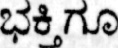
ಭಕ್ತಿಗೂ
